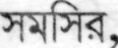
সমসির,
